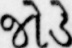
જોડે
